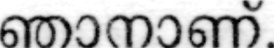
ഞാനാണ്.
